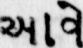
આવે
